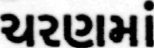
ચરણમાં
